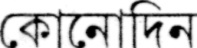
কোনোদিন
